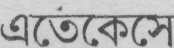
এতেকেসে
